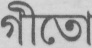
গীতো
